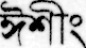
ঈশীং
